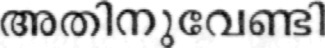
അതിനുവേണ്ടി
